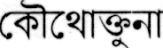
কৌথোক্তুনা
